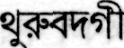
থুরুবদগী
